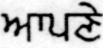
ਆਪਣੇ
